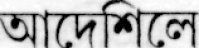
আদেশিলে
